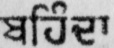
ਬਹਿੰਦਾ
